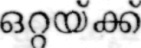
ഒറ്റയ്ക്ക്
